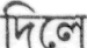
দিলে
